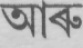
আৰু
